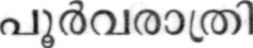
പൂര്‍വരാത്രി
